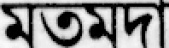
মতমদা
